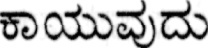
ಕಾಯುವುದು
